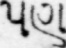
પણ
